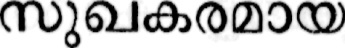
സുഖകരമായ
